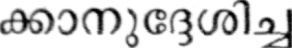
ക്കാനുദ്ദേശിച്ച
